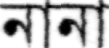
নানা
